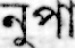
নুপা
